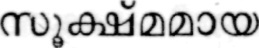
സൂക്ഷ്മമായ
